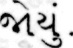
જોયું.
